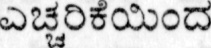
ಎಚ್ಚರಿಕೆಯಿಂದ
